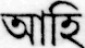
আহি
